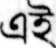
এই
